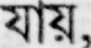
যায়,
